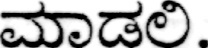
ಮಾಡಲಿ.
